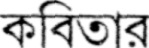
কবিতার
